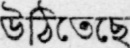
উঠিতেছে
